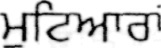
ਮੁਟਿਆਰਾਂ
